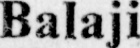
Balaji
